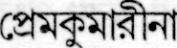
প্রেমকুমারীনা
